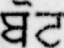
ਬੋਟ
